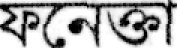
ফনেক্তা
